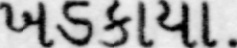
ખડકાયા.
